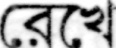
রেখে
